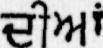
ਦੀਆਂ
